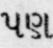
પણ
